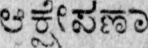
ಆಕ್ಷೇಪಣಾ
